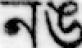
নঙ
